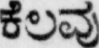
ಕೆಲವು
